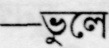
–ভুলে
